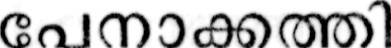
പേനാക്കത്തി
